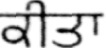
ਕੀਤਾ
